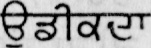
ਉਡੀਕਦਾ
